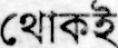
থোকই
